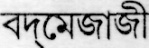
বদ্‌মেজাজী
